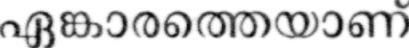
ഏങ്കാരത്തെയാണ്
